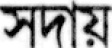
সদায়
